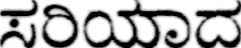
ಸರಿಯಾದ
